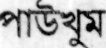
পাউখুম
